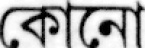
কোনো
